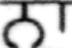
ਨਾ
